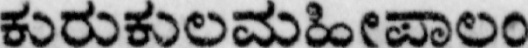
ಕುರುಕುಲಮಹೀಪಾಲಂ
